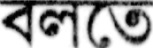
বলতে
